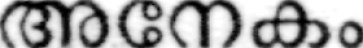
അനേകം
